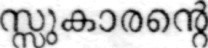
സ്സുകാരന്റെ
